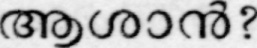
ആശാന്‍?
